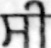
ਸੀ
